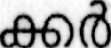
ക്കര്‍
